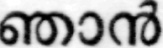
ഞാന്‍
